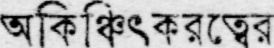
অকিঞ্চিৎকরত্বের
